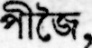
পীজৈ,
